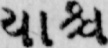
યાશ્ચ
